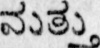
ಮತ್ತು
